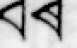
বৰ
